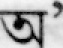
অ'
